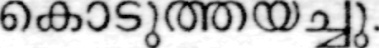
കൊടുത്തയച്ചു.
